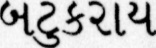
બટુકરાય
